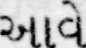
આવે
